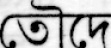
তৌদে
